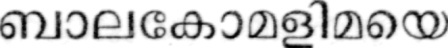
ബാലകോമളിമയെ
